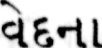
વેદના
